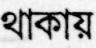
থাকায়
